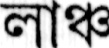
লাঞ্চ
